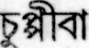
চুপ্পীবা
